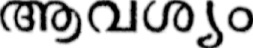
ആവശ്യം
